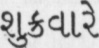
શુક્રવારે
